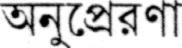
অনুপ্রেরণা
